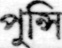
পুন্সি
